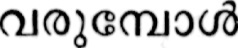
വരുമ്പോള്‍
